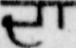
ਦਾ
